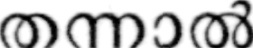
തന്നാല്‍
